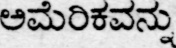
ಅಮೆರಿಕವನ್ನು
